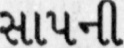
સાપની
